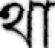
থা
